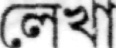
লেখা
